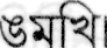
ঙমখি।
